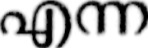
എന്ന
